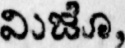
ಮಿಜೊ,
